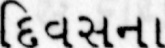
દિવસના
